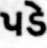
પડે
